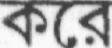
করে
